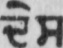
ਦੇਸ
